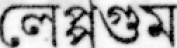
লেপ্পগুম
